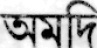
অমদি
